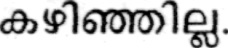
കഴിഞ്ഞില്ല.
